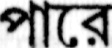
পারে
